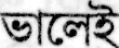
ভালেই
